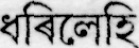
ধৰিলেহি
